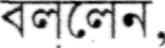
বললেন,
